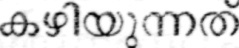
കഴിയുന്നത്
